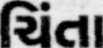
ચિંતા
